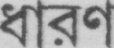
ধারণ
